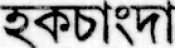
হকচাংদা
